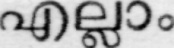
എല്ലാം
